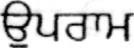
ਉਪਰਾਮ
